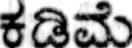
ಕಡಿಮೆ
